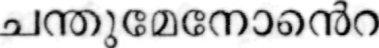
ചന്തുമേനോന്റെ
